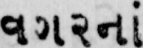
વગરનાં
